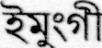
ইমুংগী
